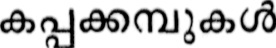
കപ്പക്കമ്പുകള്‍
